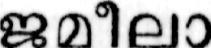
ജമീലാ
